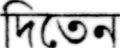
দিতেন
